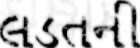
લડતની
